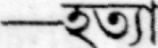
–হত্যা
